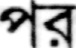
পর
